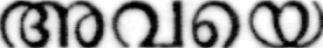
അവയെ
